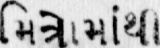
મિત્રોમાંથી
